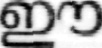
ഈ
